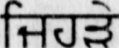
ਜਿਹੜੇ
